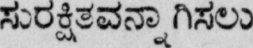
ಸುರಕ್ಷಿತವನ್ನಾಗಿಸಲು
